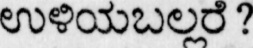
ಉಳಿಯಬಲ್ಲರೆ?
